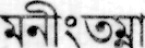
মনীংতম্না
